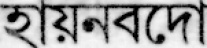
হায়নবদো
